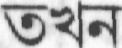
তখন
